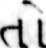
તો
